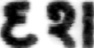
દશ
